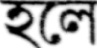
হলে
